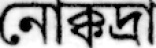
নোক্কদ্রা
